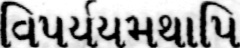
વિપર્યયમથાપિ
